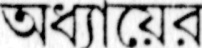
অধ্যায়ের
